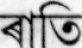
ৰাতি
